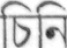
চিনি
